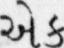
એક
